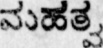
ಮಹತ್ವ
